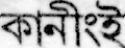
কানীংই
